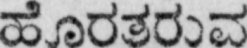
ಹೊರತರುವ
